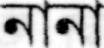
নানা
